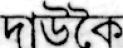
দাউকৈ
